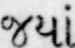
જ્યાં
